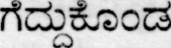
ಗೆದ್ದುಕೊಂಡ
